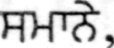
ਸਮਾਨੇ,
